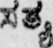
ಸತ್ಯ
